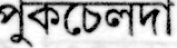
পুকচেলদা
